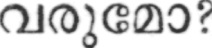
വരുമോ?
